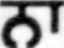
ਨਾ
